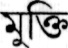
মুক্তি
